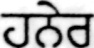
ਹਨੇਰ
